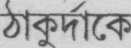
ঠাকুর্দাকে
